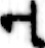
ન
